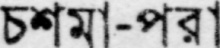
চশমা-পরা
